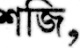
শজি,
